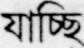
যাচ্ছি
